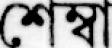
শেম্বা
